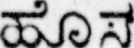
ಹೊಸ
